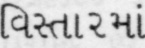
વિસ્તારમાં
